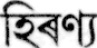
হিৰণ্য
